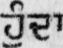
ਹੁੰਦਾ
